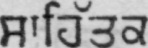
ਸਾਹਿੱਤਕ
